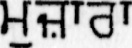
ਮੁਜ਼ਾਰਾ
